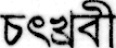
চৎখ্রবী
